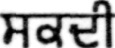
ਸਕਦੀ
